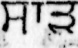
ਸਾੜ
